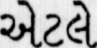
એટલે
